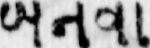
બનવા
